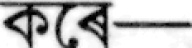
কৰে-
